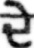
ਦੇ
